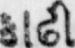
કાઢી
